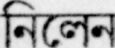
নিলেন
